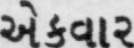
એકવાર
